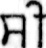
ਸੀ
